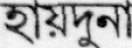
হায়দুনা
